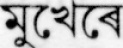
মুখেৰে
